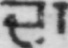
ਦਾ
